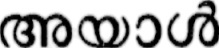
അയാള്‍
